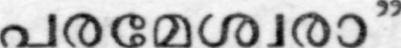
പരമേശ്വരാ”
